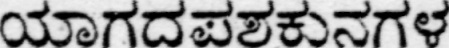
ಯಾಗದಪಶಕುನಗಳ
